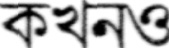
কখনও
